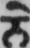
ਨੇ
